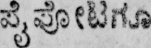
ಪೈಪೋಟಿಗೂ
